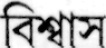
বিশ্বাস
